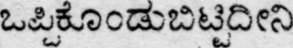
ಒಪ್ಪಿಕೊಂಡುಬಿಟ್ಟಿದೀನಿ
